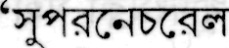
‘সুপরনেচরেল
